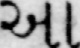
આ
